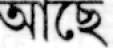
আছে
